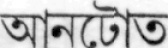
আনটোত
